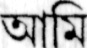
আমি
